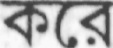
করে
